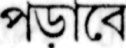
পড়াবে
